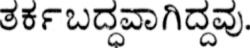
ತರ್ಕಬದ್ಧವಾಗಿದ್ದವು.
